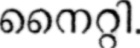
നൈറ്റി.
